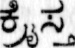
ಕ್ರೈಸ್ತ
